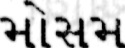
મોસમ
